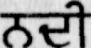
ਨਦੀ
